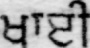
ਖਾਈ
